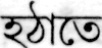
হঠাতে
